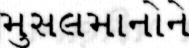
મુસલમાનોને
